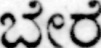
ಬೇರೆ
